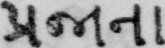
પ્રજાના
